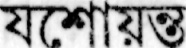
যশোয়ন্ত
